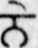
ਨੇ
